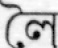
লৈ
